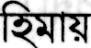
হিমায়
